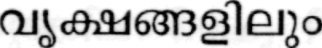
വൃക്ഷങ്ങളിലും
